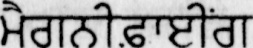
ਮੈਗਨੀਫ਼ਾਈਂਗ
